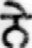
ਨੇ
